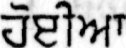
ਹੋਈਆ
